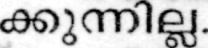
ക്കുന്നില്ല.
